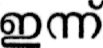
ഇന്ന്
